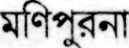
মণিপুরনা
